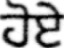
ਹੋਏ
